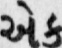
એક
